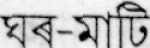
ঘৰ-মাটি
